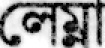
লেম্না
